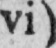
vi)
